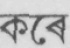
কৰে
